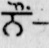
ਨੌਂ-
